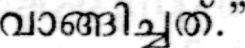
വാങ്ങിച്ചത്.”
